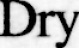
Dry
